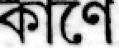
কাণে
